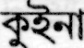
কুইনা
